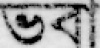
ভবা
